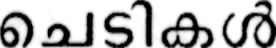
ചെടികള്‍
